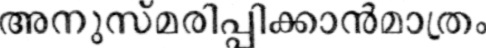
അനുസ്മരിപ്പിക്കാന്‍മാത്രം
